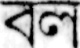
বল
